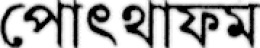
পোৎথাফম
